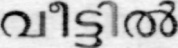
വീട്ടില്‍
